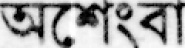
অশেংবা
